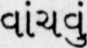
વાંચવું
